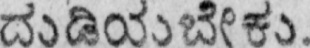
ದುಡಿಯಬೇಕು.
